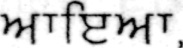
ਆਇਆ,
